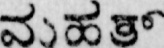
ಮಹತ್
